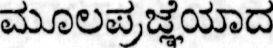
ಮೂಲಪ್ರಜ್ಞೆಯಾದ
